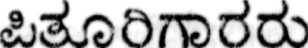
ಪಿತೂರಿಗಾರರು
